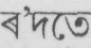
ৰ'দতে
